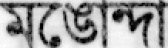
মঙোন্দা
